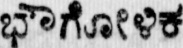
ಭೌಗೋಳಿಕ
